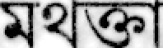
মথক্তা
